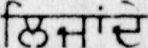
ਲਿਜਾਂਦੇ
